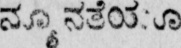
ನ್ಯೂನತೆಯೂ
